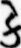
કે
